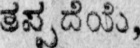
ತಪ್ಪದೆಯೆ,
